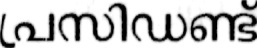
പ്രസിഡണ്ട്
